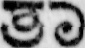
ತಾ
